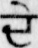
ਦੇ
